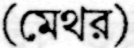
(মেথর)
